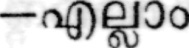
-എല്ലാം
